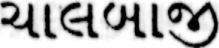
ચાલબાજી
